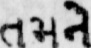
તમને
